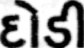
દોડી
